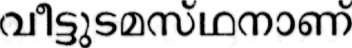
വീട്ടുടമസ്ഥനാണ്
